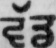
ਵੱਡ
